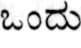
ಒಂದು
